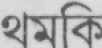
থমকি
